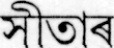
সীতাৰ
